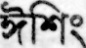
ঈশিং
